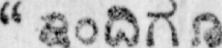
“ಇಂದಿಗೂ
